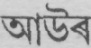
আউৰ
